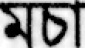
মচা
